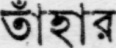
তাঁহার
